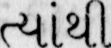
ત્યાંથી
